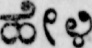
ಹೇಳಿ
